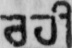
ਰਹੀ
